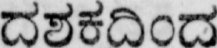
ದಶಕದಿಂದ
